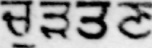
ਚੁੜਤਣ
